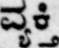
ವ್ಯಕ್ತಿ
